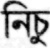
নিচু
